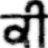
ਕੀ
